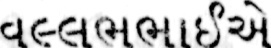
વલ્લભભાઈએ
